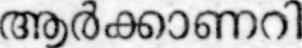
ആര്‍ക്കാണറി
